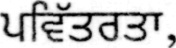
ਪਵਿੱਤਰਤਾ,
